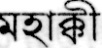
মহাক্কী
